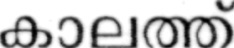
കാലത്ത്
